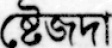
ষ্টেজদা
